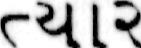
ત્યાર
